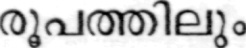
രൂപത്തിലും
